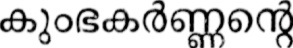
കുംഭകര്‍ണ്ണന്റെ
